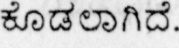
ಕೊಡಲಾಗಿದೆ.
